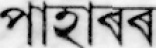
পাহাৰৰ
